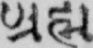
બ્રહ્મ
